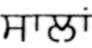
ਸਾਲਾਂ
